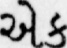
એક
